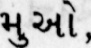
મુઓ,
